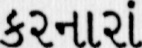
કરનારાં
